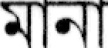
মানা
